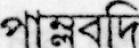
পাম্লবদি
